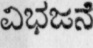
ವಿಭಜನೆ
